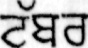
ਟੱਬਰ
